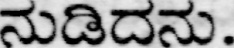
ನುಡಿದನು.
